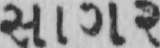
સાગર
